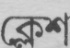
ক্লেশ
